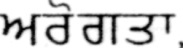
ਅਰੋਗਤਾ,
